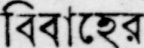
বিবাহের
